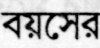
বয়সের
